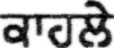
ਕਾਹਲੇ
